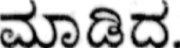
ಮಾಡಿದ.
